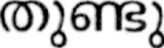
തുണ്ടു
